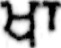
ਖਾ
